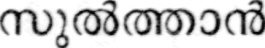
സുല്‍ത്താന്‍
